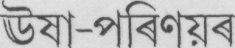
ঊষা-পৰিণয়ৰ
